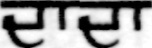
ਦਾਦਾ
